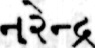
નરેન્દ્ર
